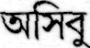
অসিবু
